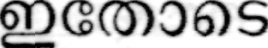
ഇതോടെ
